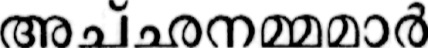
അച്ഛനമ്മമാര്‍
